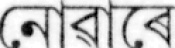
নোৱাৰে
